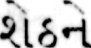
શેઠને
